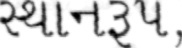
સ્થાનરૂપ,
